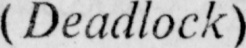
(Deadlock)
